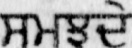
ਸਮਝਦੇ
